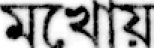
মখোয়
